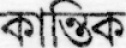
কান্তিক
